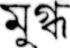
মুগ্ধ
